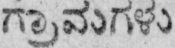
ಗ್ರಾಮಗಳು
